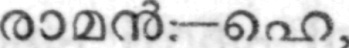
രാമന്‍:-ഹെ,
